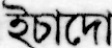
ইচাদো
